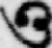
ও
